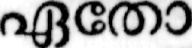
ഏതോ
